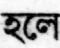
হলে
